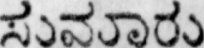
ಸುಮಾರು
